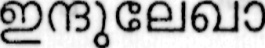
ഇന്ദുലേഖാ
